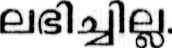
ലഭിച്ചില്ല.
